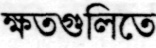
ক্ষতগুলিতে
